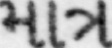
માત્ર
